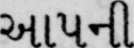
આપની
